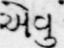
એવું
